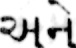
અને
